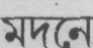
মদনে
